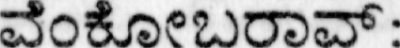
ವೆಂಕೋಬರಾವ್:
